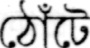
ঠোঁটে
